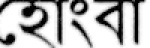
হোংবা
